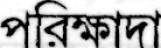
পরিক্ষাদা
